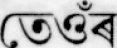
তেওঁৰ
